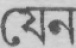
যেন
